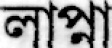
লাপ্না
